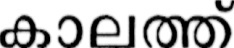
കാലത്ത്
